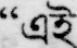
"এই
